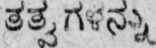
ತತ್ವಗಳನ್ನು
